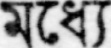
মধ্যে
